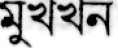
মুখখন
